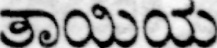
ತಾಯಿಯ
